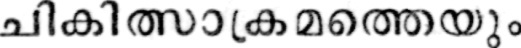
ചികിത്സാക്രമത്തെയും
